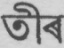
তীৰ
